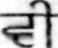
ਵੀ
